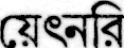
য়েৎনরি
